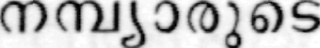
നമ്പ്യാരുടെ
